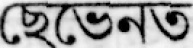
ছেভেনত
